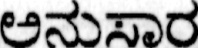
ಅನುಸಾರ
